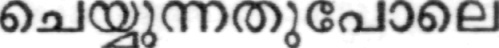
ചെയ്യുന്നതുപോലെ
